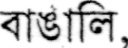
বাঙালি,
